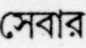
সেবার
